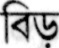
বিড়
